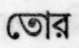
তোর
